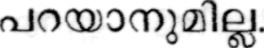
പറയാനുമില്ല.
